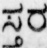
ಸ್ತರ
